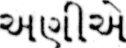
અણીએ
